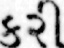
કરી
